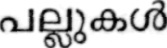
പല്ലുകള്‍
